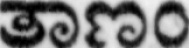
ತಾಣಂ
